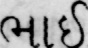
ભાઈ
